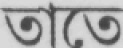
তাতে
